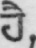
ਹੈ,
